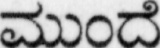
ಮುಂದೆ
